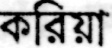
করিয়া
